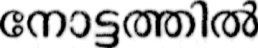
നോട്ടത്തില്‍
